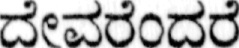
ದೇವರೆಂದರೆ
